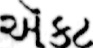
ઍક્ટ
